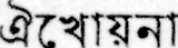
ঐখোয়না
